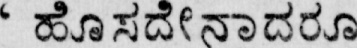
‘ಹೊಸದೇನಾದರೂ
